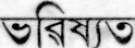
ভৱিষ্যত
